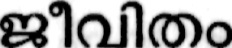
ജീവിതം
